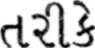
તરીકે
